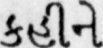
કહીને
